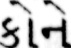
કોને
